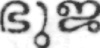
ഭുജ
